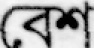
বেশ
